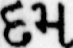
દમ
